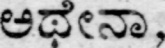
ಅಥೇನಾ,
